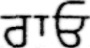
ਰਾਓ
